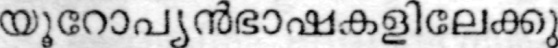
യൂറോപ്യന്‍ഭാഷകളിലേക്കു
